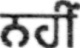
ਨਹੀਂ
